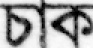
চাক
